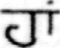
ਹਾਂ
